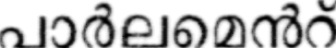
പാര്‍ലമെന്റ്
